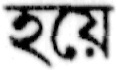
হয়ে
